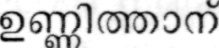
ഉണ്ണിത്താന്
